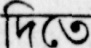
দিতে
